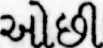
ઓછી
